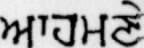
ਆਹਮਣੇ
